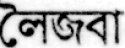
লৈজবা
